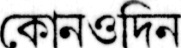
কোনওদিন
